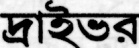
দ্রাইভর
